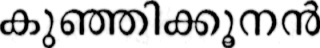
കുഞ്ഞിക്കൂനന്‍
